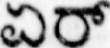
ಏರ್
